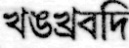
খঙখ্রবদি
